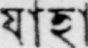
যাহা
